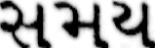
સમય
